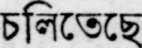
চলিতেছে
